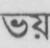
ভয়
